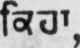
ਕਿਹਾ,
